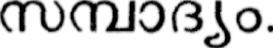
സമ്പാദ്യം.
